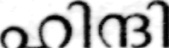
ഹിന്ദി
